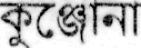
কুঞ্জোনা
